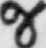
જ
